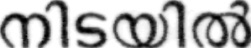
നിടയില്‍
